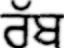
ਰੱਬ
